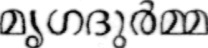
മൃഗദുര്‍മ്മ
